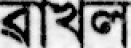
ৱাখল
